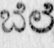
ಬೆಲೆ
